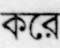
করে
